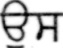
ਉਸ
